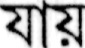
যায়
